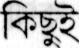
কিছুই
